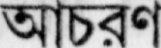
আচরণ
